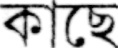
কাছে
